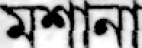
মশানা
